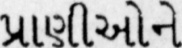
પ્રાણીઓને
